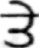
ਤੇ
